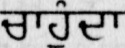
ਚਾਹੁੰਦਾ
